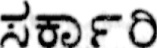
ಸರ್ಕಾರಿ
